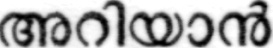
അറിയാന്‍
